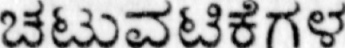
ಚಟುವಟಿಕೆಗಳ
